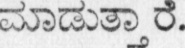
ಮಾಡುತ್ತಾರೆ.
